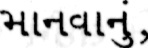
માનવાનું,
